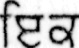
ਇਕ
